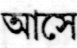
আসে
